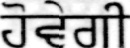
ਹੋਵੇਗੀ
